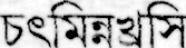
চৎমিন্নখ্রসি
